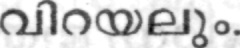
വിറയലും.
